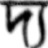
দ্য
